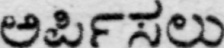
ಅರ್ಪಿಸಲು
